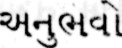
અનુભવો
